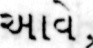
આવે,
